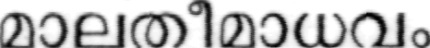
മാലതീമാധവം
